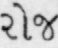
રોજ
